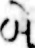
બે
